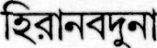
হিরানবদুনা
